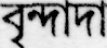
বৃন্দাদা
